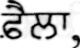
ਫ਼ੈਲਾ,
